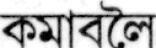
কমাবলৈ
